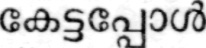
കേട്ടപ്പോള്‍
